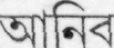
আনিব
